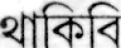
থাকিবি
